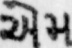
એણ
